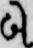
બે
